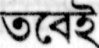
তবেই
